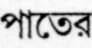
পাতের
